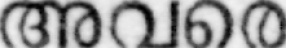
അവരെ
